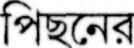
পিছনের
